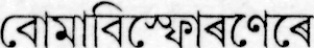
বোমাবিস্ফোৰণেৰে
